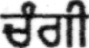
ਚੰਗੀ
